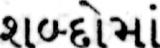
શબ્દોમાં
